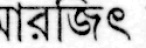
মারজিৎ
